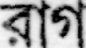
রাগ
